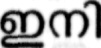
ഇനി
